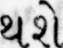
થશે
